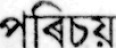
পৰিচয়
